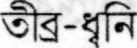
তীব্র-ধ্বনি
